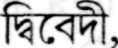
দ্বিবেদী,
